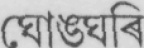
ঘোঙঘৰি
